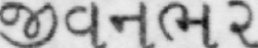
જીવનભર
